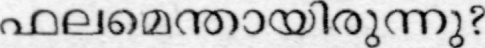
ഫലമെന്തായിരുന്നു?
